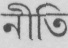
নীতি
